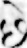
છે
